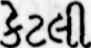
કેટલી
